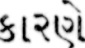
કારણે
